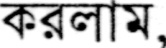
করলাম,
